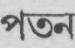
পতন
